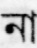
না
